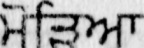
ਮੋੜਿਆ
